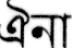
ঐনা
